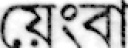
য়েংবা
